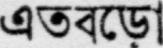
এতবড়ো
